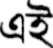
এই
